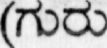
(ಗುರು
